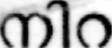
നിറ
